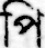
পি
